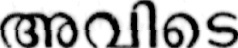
അവിടെ
